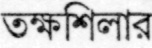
তক্ষশিলার
